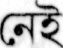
নেই
